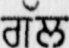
ਗੱਲ
